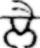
ਲੈ
